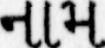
નામ
